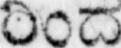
ರಿಂದ
